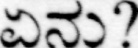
ಏನು?
